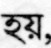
হয়,
